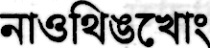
নাওথিংখোং
